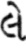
લે
